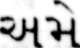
અમે
